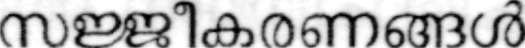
സജ്ജീകരണങ്ങള്‍
